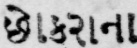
છોકરાના
